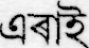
এৰাই
